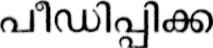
പീഡിപ്പിക്ക
